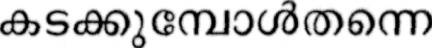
കടക്കുമ്പോള്‍തന്നെ
